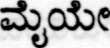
ಮೈಯೇ
